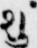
શું
